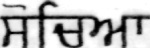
ਸੋਚਿਆ
